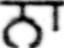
ਨਾ
